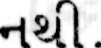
નથી.
